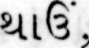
થાઉં,
